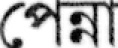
পেন্না
